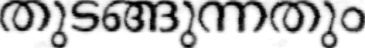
തുടങ്ങുന്നതും
